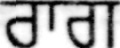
ਰਾਗ
